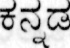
ಕನ್ನಡ
